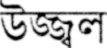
উজ্জ্বল
